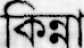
কিন্না
